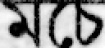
মচে
